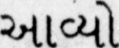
આવ્યો
